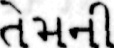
તેમની
